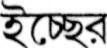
ইচ্ছের
